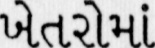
ખેતરોમાં
